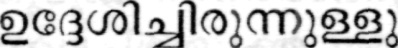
ഉദ്ദേശിച്ചിരുന്നുള്ളു
